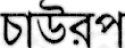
চাউরপ
